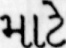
માટે
